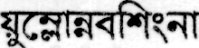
য়ুম্লোন্নবশিংনা
